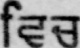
ਵਿਚ
